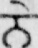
ਨੇ
